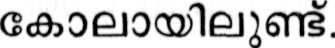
കോലായിലുണ്ട്.
